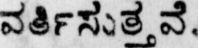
ವರ್ತಿಸುತ್ತವೆ.
